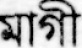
মাগী
